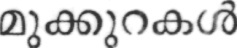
മുക്കുറകള്‍
